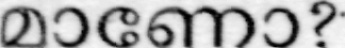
മാണോ?
